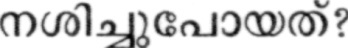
നശിച്ചുപോയത്?
